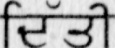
ਦਿੱਤੀ
